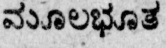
ಮೂಲಭೂತ
